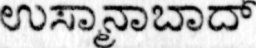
ಉಸ್ಮಾನಾಬಾದ್
